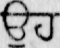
ਉਹ
